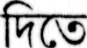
দিতে
